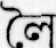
লৈ
